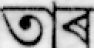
তাৰ
